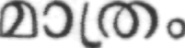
മാത്രം
